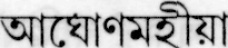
আঘোণমহীয়া
